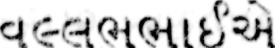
વલ્લભભાઈએ
